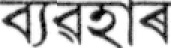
ব্যৱহাৰ
